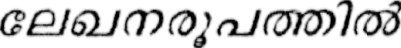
ലേഖനരൂപത്തില്‍
